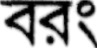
বরং
